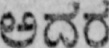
ಅದರ
